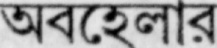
অবহেলার
